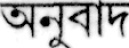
অনুবাদ
